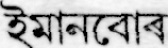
ইমানবোৰ
